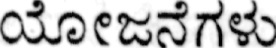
ಯೋಜನೆಗಳು
